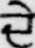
ਦੇ
